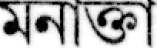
মনাক্তা
